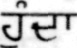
ਹੁੰਦਾ
